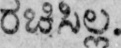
ರಚಿಸಿಲ್ಲ.
